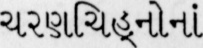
ચરણચિહનોનાં
